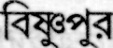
বিষ্ণুপুর
